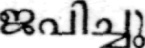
ജപിച്ചു
